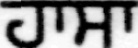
ਹਾਸਾ
